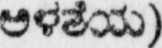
ಅಳತೆಯ)
